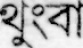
থুংবা
